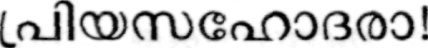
പ്രിയസഹോദരാ!
